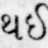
થઈ
